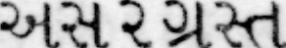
અસરગ્રસ્ત
